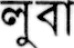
লুবা
